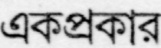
একপ্রকার
